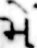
મેં
